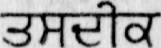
ਤਸਦੀਕ
